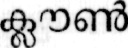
ക്ലൌണ്‍
